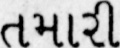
તમારી
